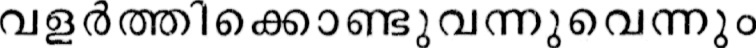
വളര്‍ത്തിക്കൊണ്ടുവന്നുവെന്നും
